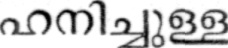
ഹനിച്ചുള്ള
